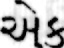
એક
